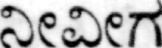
ನೀವೀಗ
